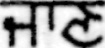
ਜਾਣ
